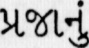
પ્રજાનું
